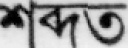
শব্দত
